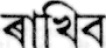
ৰাখিব
